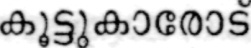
കൂട്ടുകാരോട്
